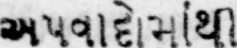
અપવાદોમાંથી
